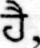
ਹੈ,
